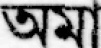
অমা
